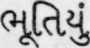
ભૂતિયું
